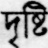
দৃষ্টি
